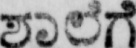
ಶಾಲೆಗೆ
